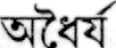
অধৈর্য
